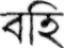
বহি
